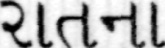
રાતના
